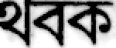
থবক
